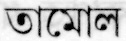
তামোল
